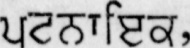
ਪਟਨਾਇਕ,
